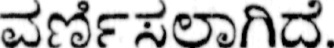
ವರ್ಣಿಸಲಾಗಿದೆ.
